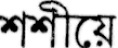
শশীয়ে
